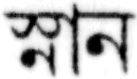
স্নান
